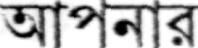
আপনার
